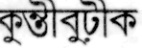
কুন্তীবুঢ়ীক
